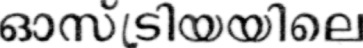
ഓസ്ട്രിയയിലെ
